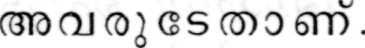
അവരുടേതാണ്.
